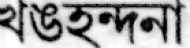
খঙহন্দনা
